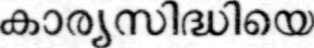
കാര്യസിദ്ധിയെ
